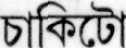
চাকিটো
